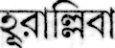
হূরাল্লিবা
